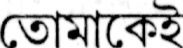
তোমাকেই
